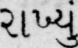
રાખ્યું
